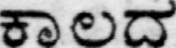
ಕಾಲದ
